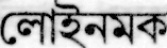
লোইনমক
